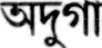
অদুগা
